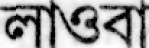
লাওবা
